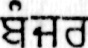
ਬੰਜਰ
